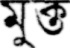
মুক্ত
